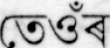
তেওঁৰ
